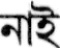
নাই
